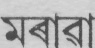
মৰাৱা
